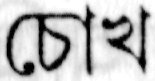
চোখ
